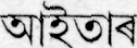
আইতাৰ
